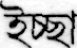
ইচ্ছা
